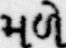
મળે
